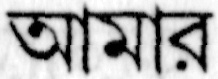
আমার
